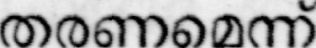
തരണമെന്ന്
